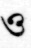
ও
